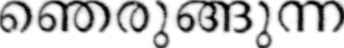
ഞെരുങ്ങുന്ന
